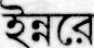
ইন্নরে
